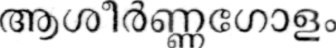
ആശീര്‍ണ്ണഗോളം
